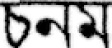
চনম
